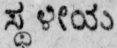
ಸ್ಥಳೀಯ
